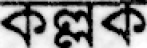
কল্লক
